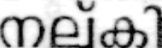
നല്കി
